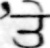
'ਤੇ
